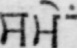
ਸਮੇਂ
